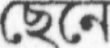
ছেনে
